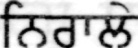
ਨਿਰਾਲੇ
